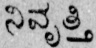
ನಿವೃತ್ತಿ
